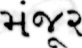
મંજૂર
